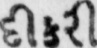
દીકરી
